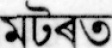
মটৰত
